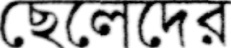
ছেলেদের
